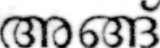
അങ്ങ്
